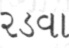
રડવા
